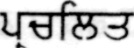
ਪ੍ਰਚਲਿਤ
